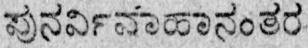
ಪುನರ್ವಿವಾಹಾನಂತರ
